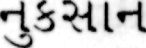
નુકસાન
